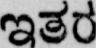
ಇತರ
